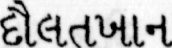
દૌલતખાન
